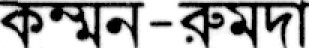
কম্মন-রুমদা
